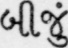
બીજું
